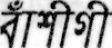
বাঁশীগী
